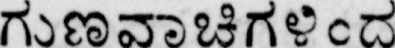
ಗುಣವಾಚಿಗಳಿಂದ
